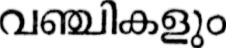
വഞ്ചികളും
